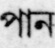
পান
